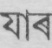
যাৰ
